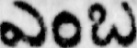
ಎಂಬ
